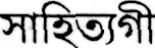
সাহিত্যগী
